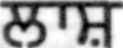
ਲਾਸ਼
